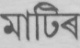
মাটিৰ
